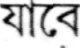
যাবে
